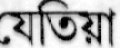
যেতিয়া
